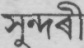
সুন্দৰী
